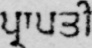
ਪ੍ਰਾਪਤੀ
